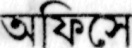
অফিসে
